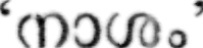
'നാശം'
